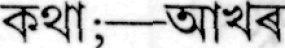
কথা;-আখৰ
